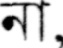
না,
